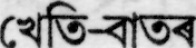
খেতি-বাতৰ
